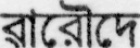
ৱারৌদে
